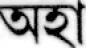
অহা
